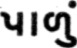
પાળું
